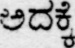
ಅದಕ್ಕೆ
